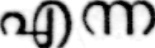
എന്ന
